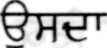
ਉਸਦਾ
